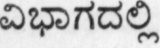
ವಿಭಾಗದಲ್ಲಿ
